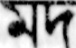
মদ
